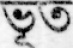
ভূত
